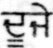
ਦੂਜੇ
